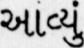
આવ્યું
